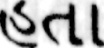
હતા
